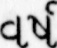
વર્ષ
